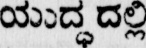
ಯುದ್ಧದಲ್ಲಿ
